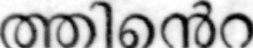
ത്തിന്റെ
